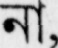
না,
